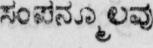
ಸಂಪನ್ಮೂಲವು
